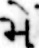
મેં
